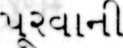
પૂરવાની
